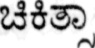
ಚಿಕಿತ್ಸಾ
